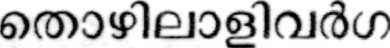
തൊഴിലാളിവര്‍ഗ
